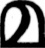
മ
